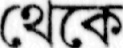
থেকে
